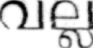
വല്ല
